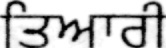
ਤਿਆਰੀ
